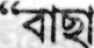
"বাছা
